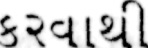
કરવાથી
